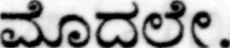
ಮೊದಲೇ,
